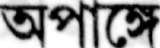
অপাঙ্গে
